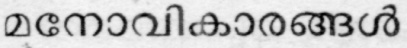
മനോവികാരങ്ങള്‍
